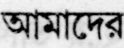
আমাদের
